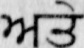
ਅਤੇ
